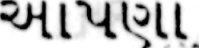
આપણા
